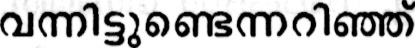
വന്നിട്ടുണ്ടെന്നറിഞ്ഞ്
